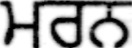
ਮਰਨ
